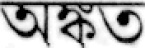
অঙ্কত
